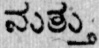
ಮತ್ತು
